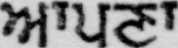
ਆਪਣਾ
